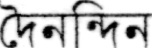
দৈনন্দিন
